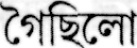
গৈছিলো
